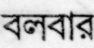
বলবার
